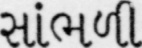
સાંભળી
